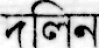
দলিন
